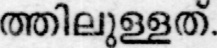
ത്തിലുള്ളത്.
